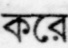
করে
